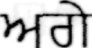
ਅਗੇ
